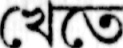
খেতে
